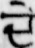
ਦੇ
